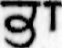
ਭਾ
